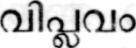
വിപ്ലവം
